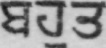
ਬਹੁਤ
